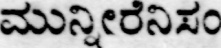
ಮುನ್ನೀರೆನಿಸಂ
